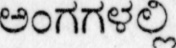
ಅಂಗಗಳಲ್ಲಿ
